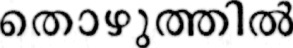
തൊഴുത്തില്‍
